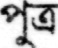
পুত্র
